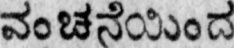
ವಂಚನೆಯಿಂದ
